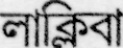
লাক্লিবা
